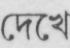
দেখে
